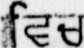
ਵਿਚ
